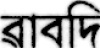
ৱাবদি
